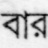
বার
